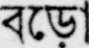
বড়ো
